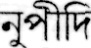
নুপীদি
